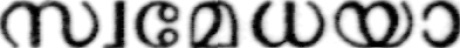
സ്വമേധയാ
